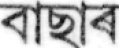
বাছাৰ
